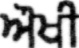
ਔਖੀ
